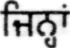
ਜਿਨ੍ਹਾਂ
